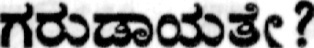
ಗರುಡಾಯತೇ?
